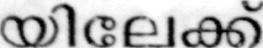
യിലേക്ക്
